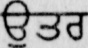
ਉਤਰ
